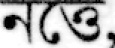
নত্তে,
